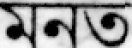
মনত
